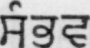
ਸੰਭਵ
